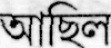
আছিল
